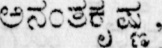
ಅನಂತಕೃಷ್ಣ,
